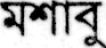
মশাবু
